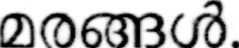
മരങ്ങള്‍.
